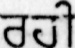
ਰਹੀ
